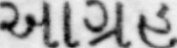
આગ્રહ
